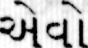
એવો
